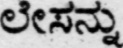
ಲೇಸನ್ನು
